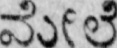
ಮೇಲೆ
